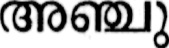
അഞ്ചു
